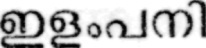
ഇളംപനി
